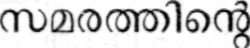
സമരത്തിന്റെ
